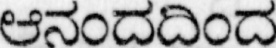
ಆನಂದದಿಂದ
